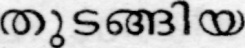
തുടങ്ങിയ
